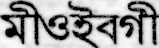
মীওইবগী
